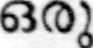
ഒരു
